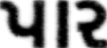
પાર
